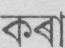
কৰা
